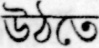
উঠতে
